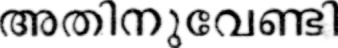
അതിനുവേണ്ടി
